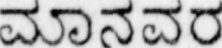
ಮಾನವರ
